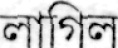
লাগিল
